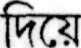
দিয়ে
